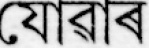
যোৱাৰ
